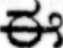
ಈ
